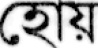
হোয়
